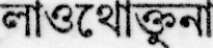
লাওথোক্তুনা
